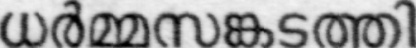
ധര്‍മ്മസങ്കടത്തി
